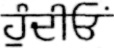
ਹੁੰਦੀਓਂ
